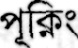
পূক্নিং
